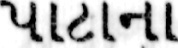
પાટાના
